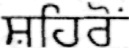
ਸ਼ਹਿਰੋਂ
